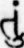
તું
